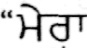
''ਮੇਰਾ
